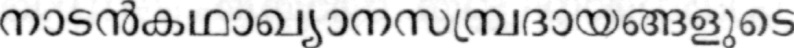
നാടന്‍കഥാഖ്യാനസമ്പ്രദായങ്ങളുടെ
